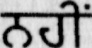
ਨਹੀਂ
